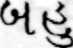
બહુ
